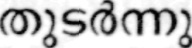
തുടര്‍ന്നു
